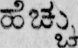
ಹೆಚ್ಚು
